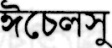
ঈচেলসু
